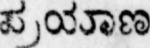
ಪ್ರಯಾಣ
